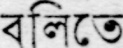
বলিতে
